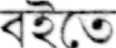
বইতে
